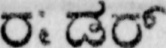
ರಾಡರ್
